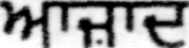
ਆਜ਼ਾਦ
